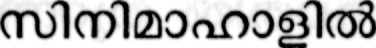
സിനിമാഹാളില്‍
